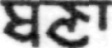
ਬਣਾ
